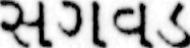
સગવડ
